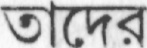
তাদের
